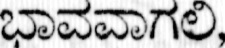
ಭಾವವಾಗಲಿ,
